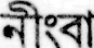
নীংবা
